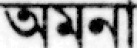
অমনা
